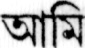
আমি
